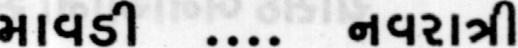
માવડી..........નવરાત્રી
